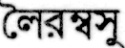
লৈরম্বসু
